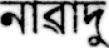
নাৱাদু
